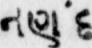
નણંદ
